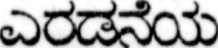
ಎರಡನೆಯ
